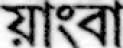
য়াংবা
